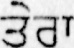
ਤੇਰਾ
